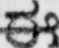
ಈ
